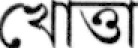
খোত্তা
